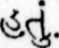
હતું.
